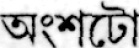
অংশটো
